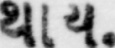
થાય.
